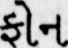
ફોન
